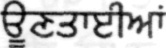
ਊਣਤਾਈਆਂ
